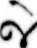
જે
